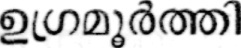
ഉഗ്രമൂര്‍ത്തി
